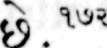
છે.૧૭૨
